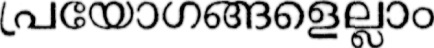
പ്രയോഗങ്ങളെല്ലാം
